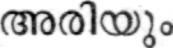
അരിയും
